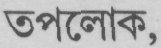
তপলোক,
